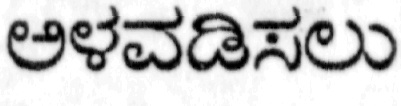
ಅಳವಡಿಸಲು
